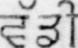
ਵੱਡੀ
